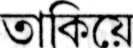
তাকিয়ে
